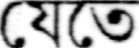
যেতে
